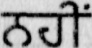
ਨਹੀਂ
